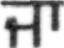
ਜਾ
